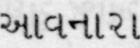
આવનારા
